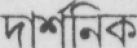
দাৰ্শনিক
